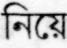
নিয়ে
